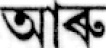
আৰু
